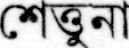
শেত্তুনা
